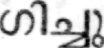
ഗിച്ചു
